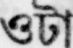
ওটা
